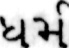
ધર્મ
